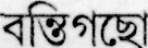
বন্তিগছো
